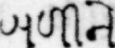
બળીને
